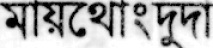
মায়থোংদুদা
